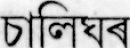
চালিঘৰ
